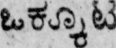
ಒಕ್ಕೂಟ
